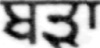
ਬੜਾ
